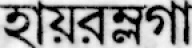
হায়রম্লগা
